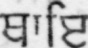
ਥਾਇ
